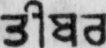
ਤੀਬਰ
